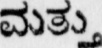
ಮತ್ತು
